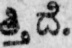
ತ್ತಿದೆ.
